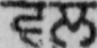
ਵਲ
